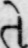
તે
